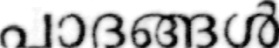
പാദങ്ങള്‍
